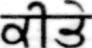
ਕੀਤੇ
